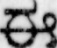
ಈ
